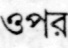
ওপর
